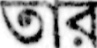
তার
